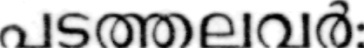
പടത്തലവര്‍:
